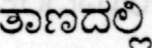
ತಾಣದಲ್ಲಿ
